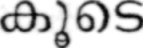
കൂടെ
